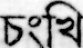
চংখি
